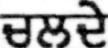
ਚਲਦੇ
